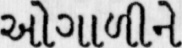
ઓગાળીને
